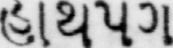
હાથપગ
